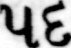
પદ
